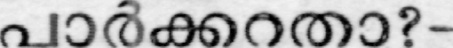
പാര്‍ക്കറതാ?-
